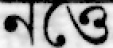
নত্তে
